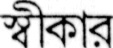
স্বীকার
